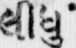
લીધું
